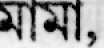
মামা,
